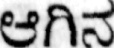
ಆಗಿನ
